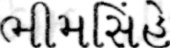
ભીમસિંહે
